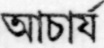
আচার্য
